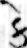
કે
